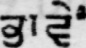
ਭਾਵੇਂ
